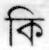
কি
